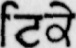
ਟਿਕੇ
